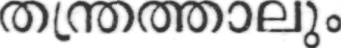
തന്ത്രത്താലും
